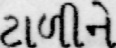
ટાળીને
